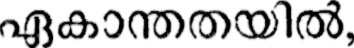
ഏകാന്തതയില്‍,
